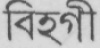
বিহগী
